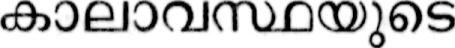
കാലാവസ്ഥയുടെ
